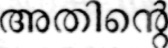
അതിന്റെ
